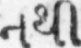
નથી
